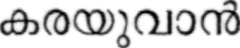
കരയുവാന്‍
